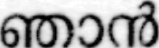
ഞാന്‍
